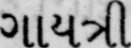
ગાયત્રી
